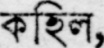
কহিল,
